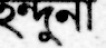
হন্দুনা
